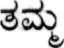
ತಮ್ಮ
